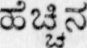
ಹೆಚ್ಚಿನ
